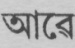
আৱে
